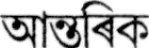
আন্তৰিক
